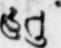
હતું
